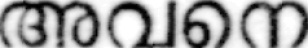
അവനെ
